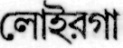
লোইরগা
